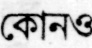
কোনও
